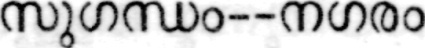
സുഗന്ധം--നഗരം
